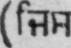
(ਜਿਸ
